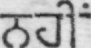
ਨਹੀਂ
